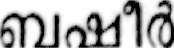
ബഷീര്‍
